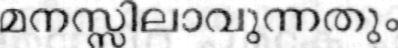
മനസ്സിലാവുന്നതും
